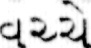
વચ્ચે
